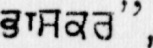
ਭਾਸਕਰ'',
